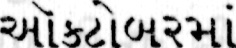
ઑક્ટોબરમાં
